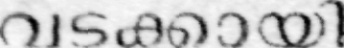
വടക്കായി
